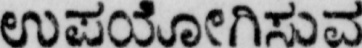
ಉಪಯೋಗಿಸುವ
